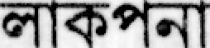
লাকপনা
